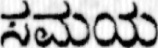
ಸಮಯ
